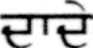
ਦਾਦੇ
